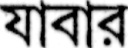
যাবার
